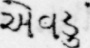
એવડું
